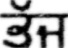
ਭੱਜ
